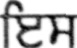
ਇਸ
